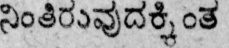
ನಿಂತಿರುವುದಕ್ಕಿಂತ
